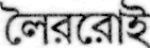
লৈররোই
